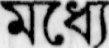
মধ্যে
